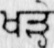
ਖੜੇ
